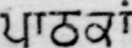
ਪਾਠਕਾਂ
